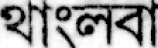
থাংলবা
